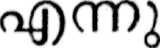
എന്നു
